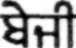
ਬੇਜੀ
